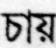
চায়
